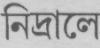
নিদ্ৰালে
